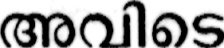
അവിടെ
